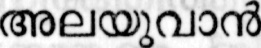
അലയുവാന്‍
